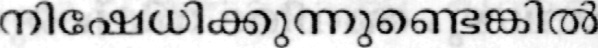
നിഷേധിക്കുന്നുണ്ടെങ്കില്‍
